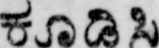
ಕೂಡಿಸಿ
